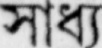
সাধ্য
